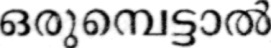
ഒരുമ്പെട്ടാല്‍
